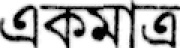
একমাত্র
